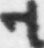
ન
